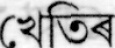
খেতিৰ
